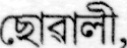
ছোৱালী,
